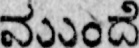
ಮುಂದೆ
